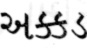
અક્કડ
